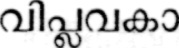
വിപ്ലവകാ
